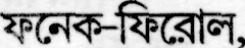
ফনেক-ফিরোল,
